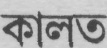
কালত
